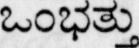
ಒಂಭತ್ತು
